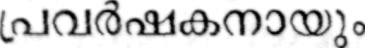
പ്രവര്‍ഷകനായും
